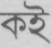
কই
